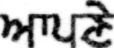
ਆਪਣੇ
